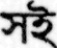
সই
